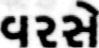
વરસે
